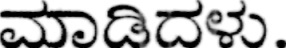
ಮಾಡಿದಳು.
